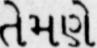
તેમણે
